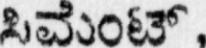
ಸಿಮೆಂಟ್,
